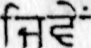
ਜਿਵੇਂ
